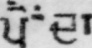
ਪੈਂਦਾ
